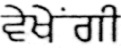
ਵੇਖੇਂਗੀ
